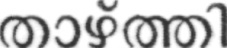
താഴ്ത്തി
